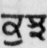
ਕੁਝ
